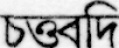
চত্তবদি
